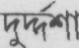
দুৰ্দ্দশা
